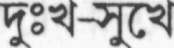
দুঃখ-সুখে
